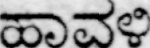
ಹಾವಳಿ
